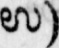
ಉ)
